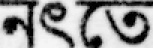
নৎতে
